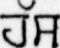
ਹੱਸ
